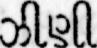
ઝીણી
